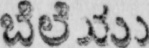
ಬೆಲೆಯು
